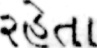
રહેતા
